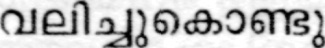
വലിച്ചുകൊണ്ടു
